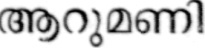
ആറുമണി
